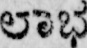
ಲಾಭ
